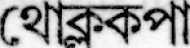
থোক্লকপা
